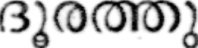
ദൂരത്തു
